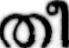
തീ
